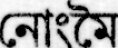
নোংমৈ
